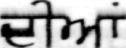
ਦੀਆਂ
